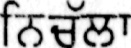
ਨਿਚੱਲਾ
